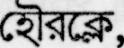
হৌরক্লে,
